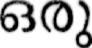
ഒരു
